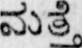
ಮತ್ತೆ
